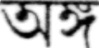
অঙ্গ
